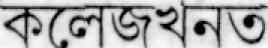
কলেজখনত
